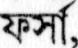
ফর্সা,
